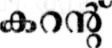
കറന്റ്
